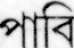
পাবি
